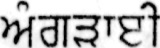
ਅੰਗੜਾਈ
